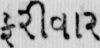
ફરીવાર
